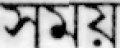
সময়
